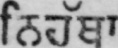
ਨਿਹੱਥਾ
